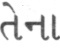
તેના
